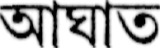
আঘাত
